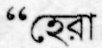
“হেরা
